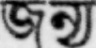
জন্য
